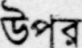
উপর
